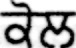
ਕੋਲ
